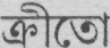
ক্ৰীতো
